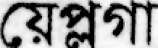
য়েপ্লগা
